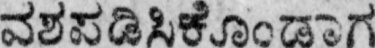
ವಶಪಡಿಸಿಕೊಂಡಾಗ
